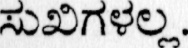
ಸುಖಿಗಳಲ್ಲ.
